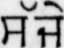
ਸੱਜੇ
